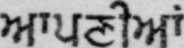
ਆਪਣੀਆਂ
